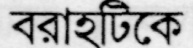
বরাহটিকে
